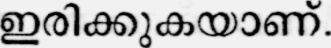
ഇരിക്കുകയാണ്.
